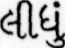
લીધું
